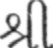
શ્રી
